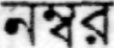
নম্বর
